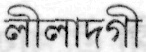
লীলাদগী
